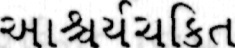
આશ્ચર્યચકિત
